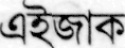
এইজাক
